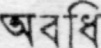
অবধি
